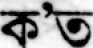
ক'ত
